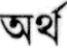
অর্থ
